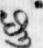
છું
